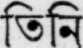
তিনি
